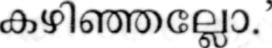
കഴിഞ്ഞല്ലോ.'
